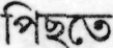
পিছতে
